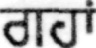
ਗਹਾਂ
